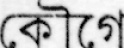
কৌগে
